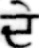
ਦੇ
